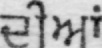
ਦੀਆਂ
